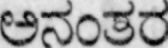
ಅನಂತರ
